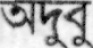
অদুবু
